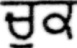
ਚੁਕ
